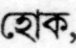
হোক,
